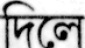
দিলে
